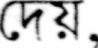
দেয়,
